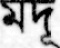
মদূ
